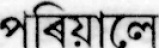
পৰিয়ালে
